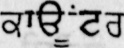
ਕਾਊਂਟਰ
